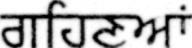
ਗਹਿਣਆਂ
